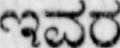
ಇವರ
